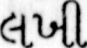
લખી
